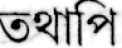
তথাপি
